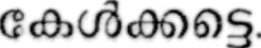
കേള്‍ക്കട്ടെ.
